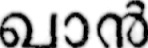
ഖാന്‍
